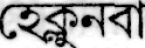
হেক্লুনবা
